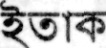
ইতাক
